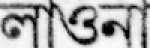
লাওনা
